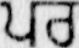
ਪਰ
